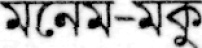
মনেম-মকু
